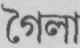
গৈলা
